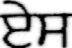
ਏਸ
